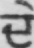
ਦੇ
